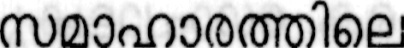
സമാഹാരത്തിലെ
